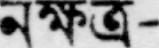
নক্ষত্র-
